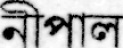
নীপাল
